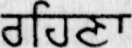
ਰਹਿਣਾ
